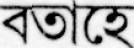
বতাহে
